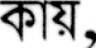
কায়,
